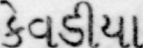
કેવડીયા
